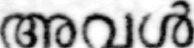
അവള്‍
